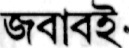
জবাবই
